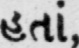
હતાં,
